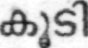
കൂടി
